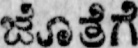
ಜೊತೆಗೆ
